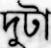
দুটা
